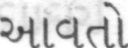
આવતો
